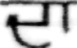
ਦਾ
